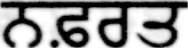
ਨਫ਼ਰਤ
